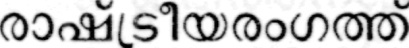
രാഷ്ട്രീയരംഗത്ത്
